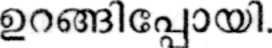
ഉറങ്ങിപ്പോയി.
